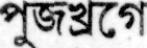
পুজখ্রগে
